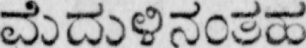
ಮೆದುಳಿನಂತಹ
